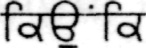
ਕਿਉਂਕਿ
